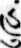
હું
